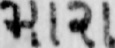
મારા
